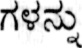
ಗಳನ್ನು
